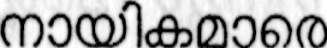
നായികമാരെ
